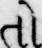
તો
